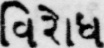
વિરોધ
